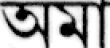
অমা
